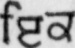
ਇਕ
